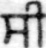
ਸੀ
